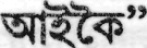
আইকৈ"
